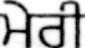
ਮੇਰੀ
